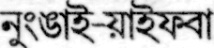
নুংঙাই-য়াইফবা
